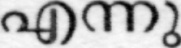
എന്നു
